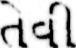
તેવી
